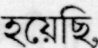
হয়েছি,
